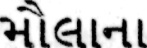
મૌલાના
